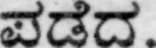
ಪಡೆದ.
